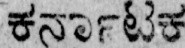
ಕರ್ನಾಟಕ
